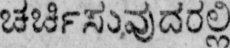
ಚರ್ಚಿಸುವುದರಲ್ಲಿ
